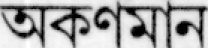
অকণমান
